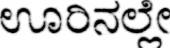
ಊರಿನಲ್ಲೇ
